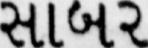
સાબર
